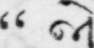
"જો
